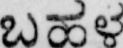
ಬಹಳ
